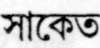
সাকেত
